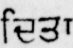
ਦਿਤਾ
